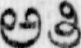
ಅತಿ
